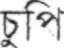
চুপি
